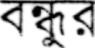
বন্ধুর
